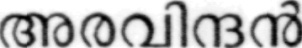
അരവിന്ദന്‍
